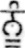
ਨੂੰ
